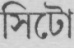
সিটো
